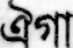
ঐগা
